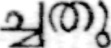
ച്ചതു
